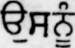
ਉਸਨੂੰ
